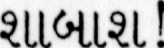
શાબાશ!
